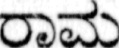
ರಾಮ
